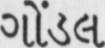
ગોંડલ
